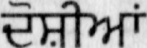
ਦੋਸ਼ੀਆਂ
